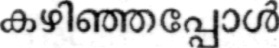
കഴിഞ്ഞപ്പോള്‍
